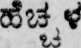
ಹೆಚ್ಚಳ
